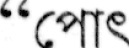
“পোৎ
